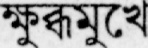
ক্ষুব্ধমুখে
